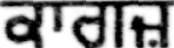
ਕਾਗਜ਼
